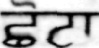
ਛੋਟਾ
